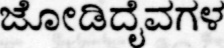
ಜೋಡಿದೈವಗಳ
